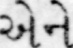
એને
